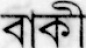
বাকী
